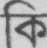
কি
